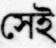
সেই
